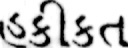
હકીકત
